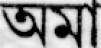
অমা
